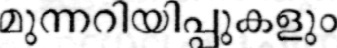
മുന്നറിയിപ്പുകളും
